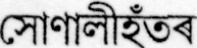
সোণালীহঁতৰ
